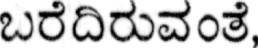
ಬರೆದಿರುವಂತೆ,
